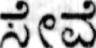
ಸೇವೆ
